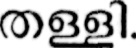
തള്ളി.
